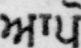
ਆਪੋ
